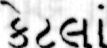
કેટલાં
